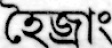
হৈজ্রাং
